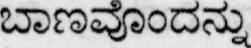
ಬಾಣವೊಂದನ್ನು
